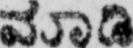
ಮಾಡಿ
